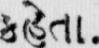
કહેતા.
